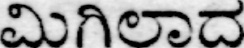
ಮಿಗಿಲಾದ
